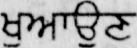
ਖੁਆਉਣ
